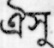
ঐসু
